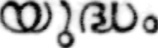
യുദ്ധം
